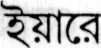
ইয়ারে
